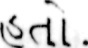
હતો.
